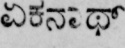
ಏಕನಾಥ್
